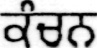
ਕੰਚਨ
